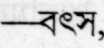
–বত্স,
